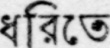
ধরিতে
